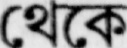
থেকে
